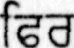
ਫਿਰ
